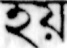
হয়
